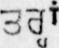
ਤਰ੍ਹਾਂ
